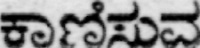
ಕಾಣಿಸುವ
